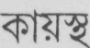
কায়স্থ
